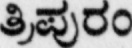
ತ್ರಿಪುರಂ
